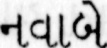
નવાબે
